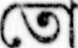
তো
